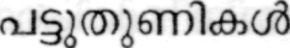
പട്ടുതുണികള്‍
